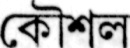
কৌশল
